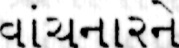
વાંચનારને
